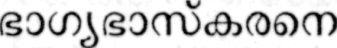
ഭാഗ്യഭാസ്കരനെ
